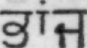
ਭਾਂਜ
